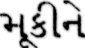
મૂકીને
